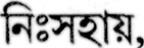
নিঃসহায়,
